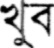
খুব
